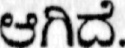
ಆಗಿದೆ.
